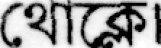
থোক্লে।
